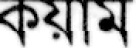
কয়াম
